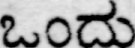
ಒ೦ದು
